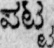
ಪಟ್ಟ
